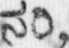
ನರಿ,
